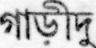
গাড়ীদু
